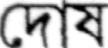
দোষ
